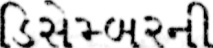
ડિસેમ્બરની
